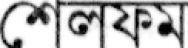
শেলফম
